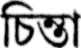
চিন্তা
